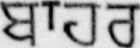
ਬਾਹਰ
